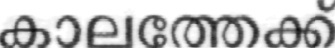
കാലത്തേക്ക്
